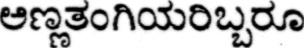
ಅಣ್ಣತಂಗಿಯರಿಬ್ಬರೂ
